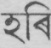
হৰি
